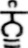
ਨੂੰ
